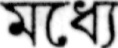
মধ্যে
